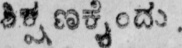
ಶಿಕ್ಷಣಕ್ಕೆಂದು.
